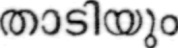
താടിയും
